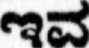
ಇವ
